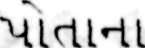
પોતાના
